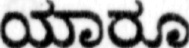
ಯಾರೂ
